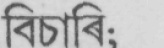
বিচাৰি;
